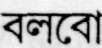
বলবো
